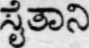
ಸೈತಾನಿ
